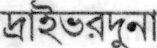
দ্রাইভরদুনা
